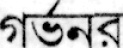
গর্ভনর
